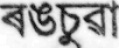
ৰঙচুৱা
